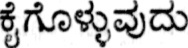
ಕೈಗೊಳ್ಳುವುದು
